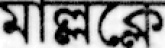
মাল্লক্লে
